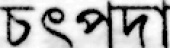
চৎপদা
